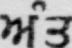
ਅੰਤ
